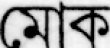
মোক
